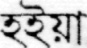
হইয়া
